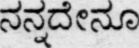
ನನ್ನದೇನೂ
